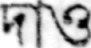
দাও
